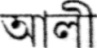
আলী
